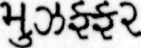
મુઝફ્ફર
